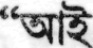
"আই
